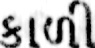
કાળી
